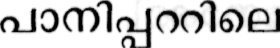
പാനിപ്പററിലെ
